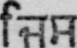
ਜਿਸ
